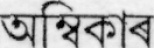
অম্বিকাৰ
